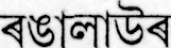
ৰঙালাউৰ
